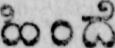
ಹಿಂದೆ
